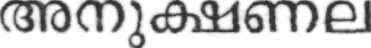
അനുക്ഷണല
